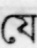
যে
